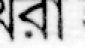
খরা
